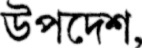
উপদেশ,
